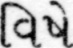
વિષે
